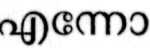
എന്നോ
